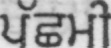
ਪੱਛਮੀ
